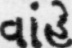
વાંહે
